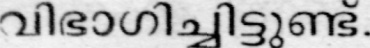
വിഭാഗിച്ചിട്ടുണ്ട്.
